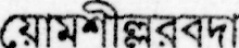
য়োমশীল্লরবদা
